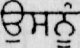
ਉਸਨੂੰ
